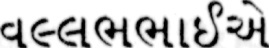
વલ્લભભાઈએ
